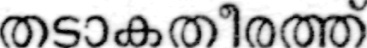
തടാകതീരത്ത്
